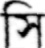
সি
